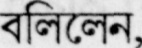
বলিলেন,
